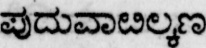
ಪುದುವಾೞಲ್ಕಣ
